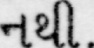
નથી.
